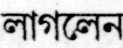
লাগলেন
